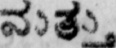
ಮತ್ತು
